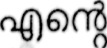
എന്റെ
